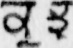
ਕੁਝ
